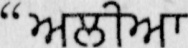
''ਅਲੀਆ
